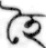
হৈ
